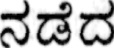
ನಡೆದ
